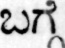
ಬಗ್ಗೆ
